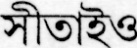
সীতাইও
